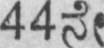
44ನೇ
